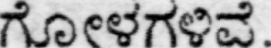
ಗೋಳಗಳಿವೆ.
